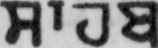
ਸਾਹਬ
